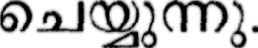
ചെയ്യുന്നു.
